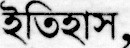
ইতিহাস,
